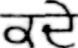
ਕਦੇ
